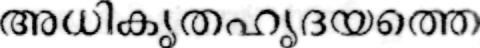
അധികൃതഹൃദയത്തെ
